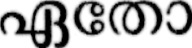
ഏതോ
